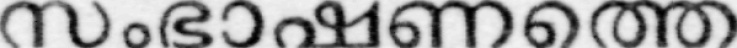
സംഭാഷണത്തെ
